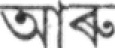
আৰু
